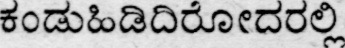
ಕ೦ಡುಹಿಡಿದಿರೋದರಲ್ಲಿ
